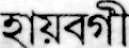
হায়বগী
